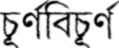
চূর্ণবিচূর্ণ
